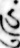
હું
